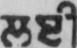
ਲਈ
